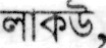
লাকউ,
